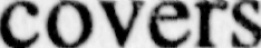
covers
